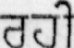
ਰਹੀ
